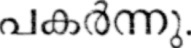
പകര്‍ന്നു.
